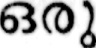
ഒരു
